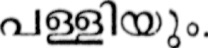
പള്ളിയും.
